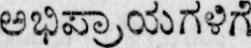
ಅಭಿಪ್ರಾಯಗಳಿಗೆ
